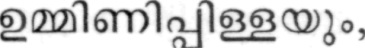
ഉമ്മിണിപ്പിള്ളയും,
